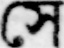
সে
